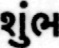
શુંભ
